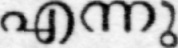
എന്നു
